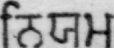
ਨਿਯਮ
